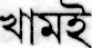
খামই
